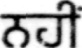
ਨਹੀਂ
